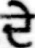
ਦੇ
